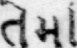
તેમાં
